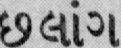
છલાંગ
